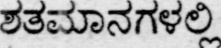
ಶತಮಾನಗಳಲ್ಲಿ
